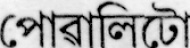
পোৱালিটো
